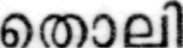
തൊലി
